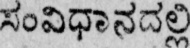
ಸಂವಿಧಾನದಲ್ಲಿ
